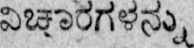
ವಿಚಾರಗಳನ್ನು
